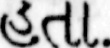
હતા.
